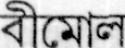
বীমোল
